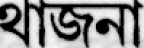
থাজনা
